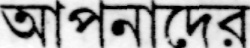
আপনাদের
